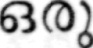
ഒരു
